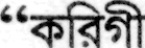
“করিগী
